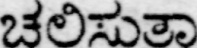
ಚಲಿಸುತಾ
